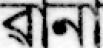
ৱানা
